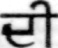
ਦੀ
